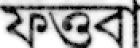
ফত্তবা
